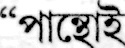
“পান্থোই
